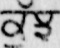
ਕੁੱਝ
